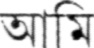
আমি
